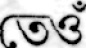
তেওঁ
